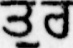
ਤੁਰ
